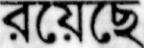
রয়েছে
